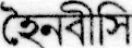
হৈনবীসি
